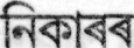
নিকাৰৰ
